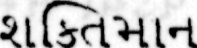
શક્તિમાન
